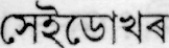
সেইডোখৰ
